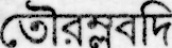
তৌরম্লবদি
